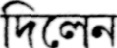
দিলেন
